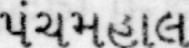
પંચમહાલ
